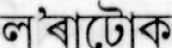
ল'ৰাটোক
